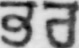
ਭਰ
